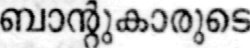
ബാന്റുകാരുടെ
